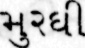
મુરઘી
